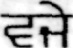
ਵਜੇ
